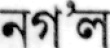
নগ'ল
